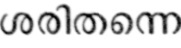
ശരിതന്നെ
